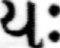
યઃ
